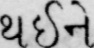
થઈને
